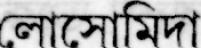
লোসোমিদা
